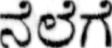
ನೆಲೆಗೆ
